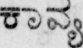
ಕಾವ್ಯ
